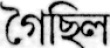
গৈছিল
